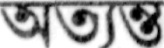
অত্যন্ত
